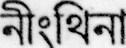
নীংথিনা
